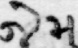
જેમ
